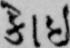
કોઈ
